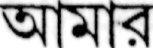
আমার
